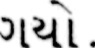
ગયો.
